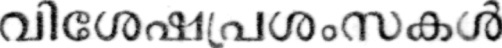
വിശേഷപ്രശംസകള്‍
